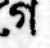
গ
